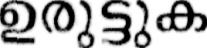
ഉരുട്ടുക
